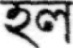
হল
